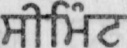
ਸੀਮਿੰਟ
